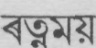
ৰত্নময়
